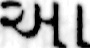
આ
